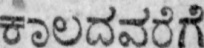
ಕಾಲದವರೆಗೆ
